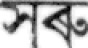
সৰু
